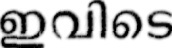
ഇവിടെ
